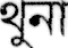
থুনা
